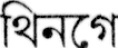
থিনগে
